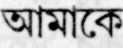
আমাকে
